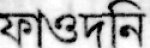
ফাওদনি
